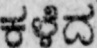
ಕಳೆದ
